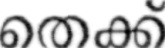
തെക്ക്
